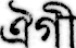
ঐগী
